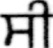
ਸੀ
